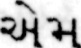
એમ
